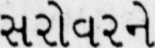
સરોવરને
